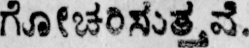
ಗೋಚರಿಸುತ್ತವೆ.
